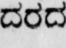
ದರದ
